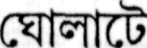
ঘোলাটে
